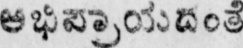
ಅಭಿಪ್ರಾಯದಂತೆ
